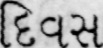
દિવસ
